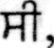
ਸੀ,
